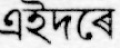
এইদৰে
